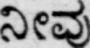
ನೀವು
